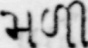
મળી
